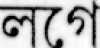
লগে
